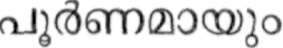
പൂര്‍ണമായും
